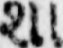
શા
